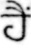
ਹੈਂ
